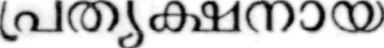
പ്രത്യക്ഷനായ
